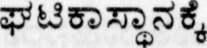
ಘಟಿಕಾಸ್ಥಾನಕ್ಕೆ
